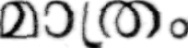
മാത്രം
